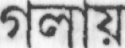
গলায়
